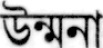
উন্মনা
